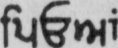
ਪਿਓਆਂ
